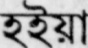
হইয়া
